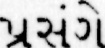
પ્રસંગે
